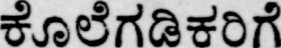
ಕೊಲೆಗಡಿಕರಿಗೆ
